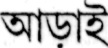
আড়াই
